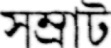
সম্রাট
